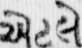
એટલે
